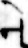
ને
